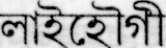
লাইহৌগী
